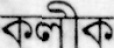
কলীক
